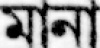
মানা
